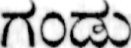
ಗಂಡು
